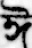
ঈ
